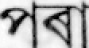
পৰা
